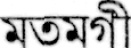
মতমগী
